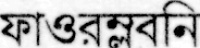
ফাওরম্লবনি
